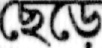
ছেড়ে
